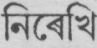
নিৰেখি
